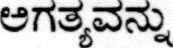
ಅಗತ್ಯವನ್ನು
